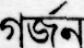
গর্জন
